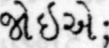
જોઈએ;
